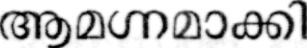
ആമഗ്നമാക്കി
